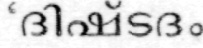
‘ദിഷ്ടദം
